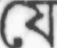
যে
